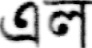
এল
